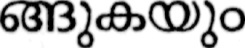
ങ്ങുകയും
